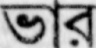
ভার
